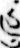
હું
